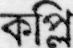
কপ্লি
